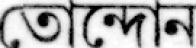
তোন্দোন
